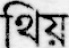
থিয়
